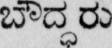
ಬೌದ್ಧರು
